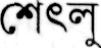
শেৎলু
